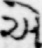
એ
